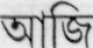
আজি
